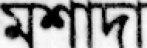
মশাদা
